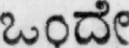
ಒಂದೇ
